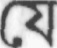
যে
